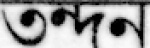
তন্দন
